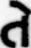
તે
